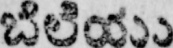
ಬೆಲೆಯು
